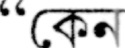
“কেন
